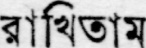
রাখিতাম
